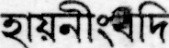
হায়নীংবদি
